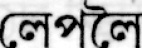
লেপলৈ
